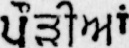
ਪੌੜੀਆਂ
